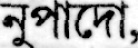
নুপাদো,
